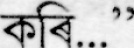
কৰি..."
